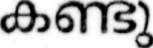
കണ്ടു
